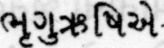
ભૃગઋષિએ
